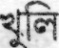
খুলি
